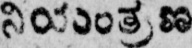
ನಿಯಂತ್ರಣ
